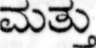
ಮತ್ತು
